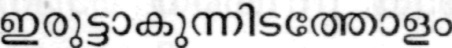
ഇരുട്ടാകുന്നിടത്തോളം
